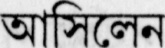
আসিলেন
